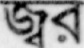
জ্বর
